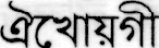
ঐখোয়গী
